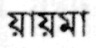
য়ায়মা
